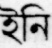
ইনি
